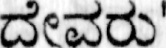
ದೇವರು’
